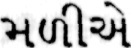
મળીએ
